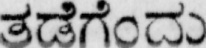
ತಡೆಗೆಂದು
